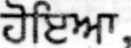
ਹੋਇਆ,
